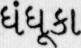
ધંધૂકા
